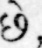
છે,
